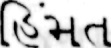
હિંમત
